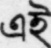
এই
